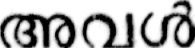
അവള്‍
